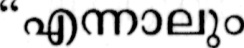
“എന്നാലും
